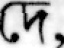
দে,
